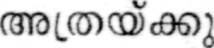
അത്രയ്ക്കു
